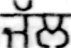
ਜੱਲ
